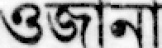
ওজানা
